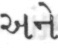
અને
